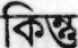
কিন্তু
